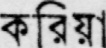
করিয়া
